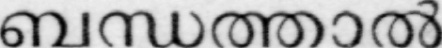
ബന്ധത്താല്‍
